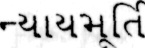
ન્યાયમૂર્તિ
